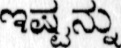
ಇಷ್ಟನ್ನು
